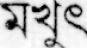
মখুৎ
